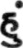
હું
